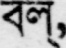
বল্,
